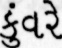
કુંવરે
